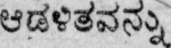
ಆಡಳಿತವನ್ನು
